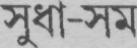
সুধা-সম
